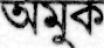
অমুক
